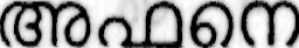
അഫനെ
